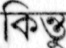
কিন্তু
